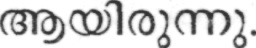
ആയിരുന്നു.
